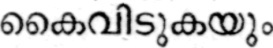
കൈവിടുകയും
